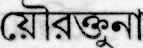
য়ৌরক্তুনা
